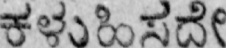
ಕಳುಹಿಸದೇ
